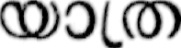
യാത്ര
